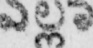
ಎಲ್ಲಾ
